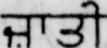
ਜ਼ਾਤੀ
